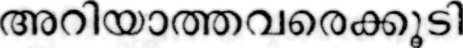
അറിയാത്തവരെക്കൂടി
